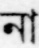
না
